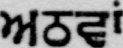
ਅਠਵਾਂ
